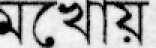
মখোয়
